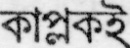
কাপ্লকই
